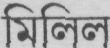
মিলিল
